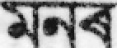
মনৰ
